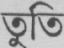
তুতি
